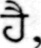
ਹੈ,
